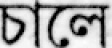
চালে
